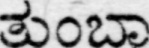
ತುಂಬಾ
